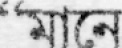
"মানে
